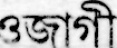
ওজাগী
